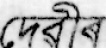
দেৱীৰ
